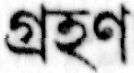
গ্রহণ
